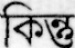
কিন্তু
